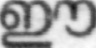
ഈ
